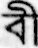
বী
